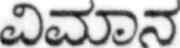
ವಿಮಾನ
